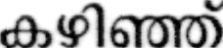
കഴിഞ്ഞ്
